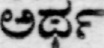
ಅರ್ಥ
